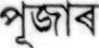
পূজাৰ
